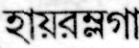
হায়রম্লগা
